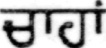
ਚਾਹਾਂ
